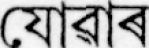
যোৱাৰ
